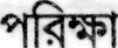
পরিক্ষা
